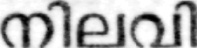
നിലവി
